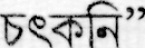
চৎকনি”
